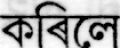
কৰিলে
